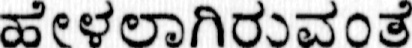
ಹೇಳಲಾಗಿರುವಂತೆ
